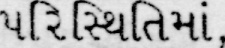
પરિસ્થિતિમાં,
